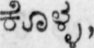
ಕೊಳ್ಳ.
